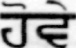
ਹੋਵੇ
